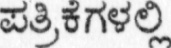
ಪತ್ರಿಕೆಗಳಲ್ಲಿ
